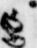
હું
